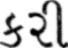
કરી
